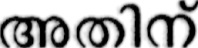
അതിന്
